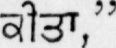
ਕੀਤਾ,''
